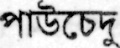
পাউচেদু
